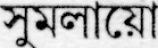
সুমলায়ো
